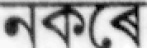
নকৰে
